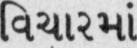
વિચારમાં
